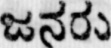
ಜನರು
